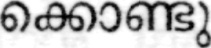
ക്കൊണ്ടു
